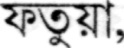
ফতুয়া,
